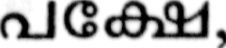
പക്ഷേ,
